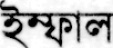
ইম্ফাল
